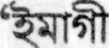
‘ইমাগী
